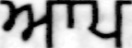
ਆਪ
